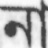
না
